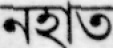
নহাত
